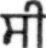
ਸੀ
